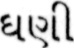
ઘણી
